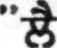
''ਲੈ
